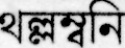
থল্লম্বনি
